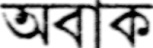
অবাক
